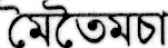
মৈতৈমচা
